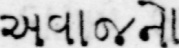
અવાજનો
